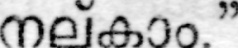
നല്കാം."
